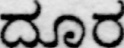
ದೂರ
